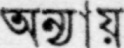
অন্যায়
